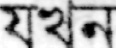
যখন
